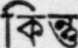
কিন্তু
